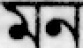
মন
